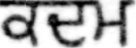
ਕਦਮ
